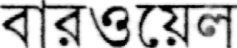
বারওয়েল
